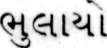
ભુલાયો
